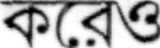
করেও
